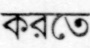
করতে
